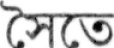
সৈতে
